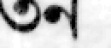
তেন
